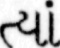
ત્યાં
